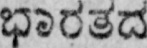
ಭಾರತದ
